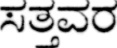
ಸತ್ತವರ
